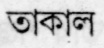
তাকাল
